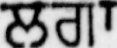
ਲਗਾ
